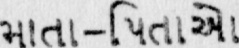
માતા-પિતાઓ
